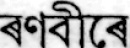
ৰণবীৰে
